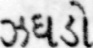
ઝઘડો
